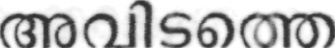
അവിടത്തെ
